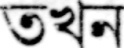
তখন
